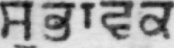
ਸੁਭਾਵਕ
